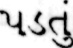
પડતું
